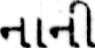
નાની
